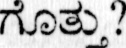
ಗೊತ್ತು?
